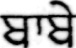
ਬਾਬੇ
